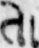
તો
